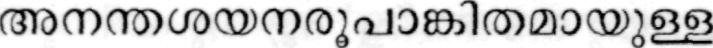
അനന്തശയനരൂപാങ്കിതമായുള്ള
